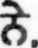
ਨੇ,
